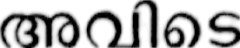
അവിടെ
